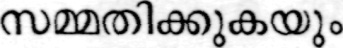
സമ്മതിക്കുകയും
